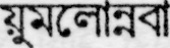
য়ুমলোন্নবা
